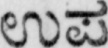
ಉಪ
